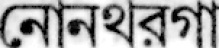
নোনথরগা
